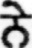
ਨੇ
